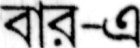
বার-এ
